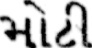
મોટી
